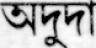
অদুদা
